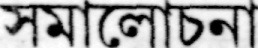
সমালোচনা
